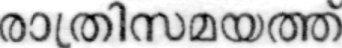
രാത്രിസമയത്ത്
